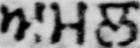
ਅਮਲ
